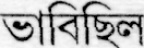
ভাবিছিল
